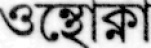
ওন্থোক্না
